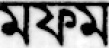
মফম
